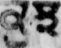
ਕੁਝ
